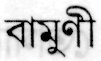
বামুণী
